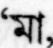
‘মা,
